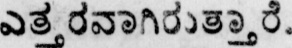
ಎತ್ತರವಾಗಿರುತ್ತಾರೆ.
